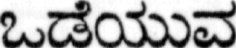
ಒಡೆಯುವ
